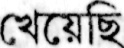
খেয়েছি
